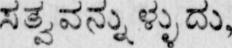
ಸತ್ವವನ್ನುಳ್ಳುದು,
